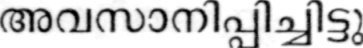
അവസാനിപ്പിച്ചിട്ടു
